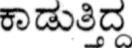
ಕಾಡುತ್ತಿದ್ದ
